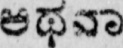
ಅಥವಾ
